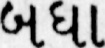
બધા
